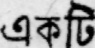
একটি
